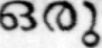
ഒരു
